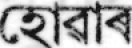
হোৱাৰ
